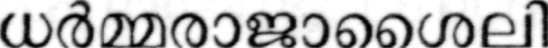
ധര്‍മ്മരാജാശൈലി
